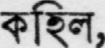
কহিল,
